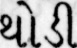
થોડી
